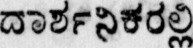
ದಾರ್ಶನಿಕರಲ್ಲಿ
